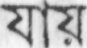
যায়
